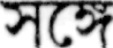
সঙ্গে
